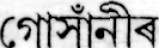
গোসাঁনীৰ
